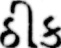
ઠીક
